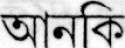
আনকি
